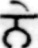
ਨੇ
